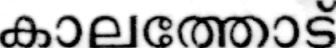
കാലത്തോട്
